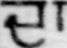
ਦਾ
